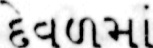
દેવળમાં
